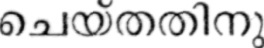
ചെയ്തതിനു
